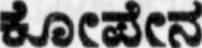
ಕೋಪೇನ
